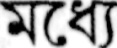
মধ্যে
